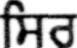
ਸਿਰ
